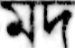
মদ
